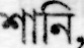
শানি,
